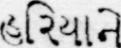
હરિયાને
